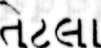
તેટલા
